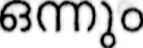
ഒന്നും
